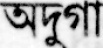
অদুগা
